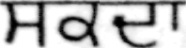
ਸਕਦਾ
